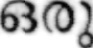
ഒരു
